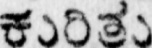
ಕುರಿತು
